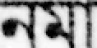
নমা
